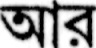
আর
